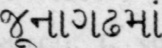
જૂનાગઢમાં
